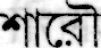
শারৌ
